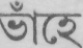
ভাঁহে
